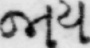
જાય
